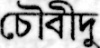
চৌবীদু
